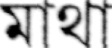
মাথা
